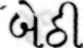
બેઠી
